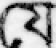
যে
